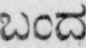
ಬಂದ
